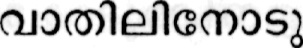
വാതിലിനോടു
